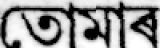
তোমাৰ
